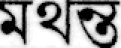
মথন্ত
